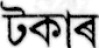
টকাৰ
